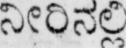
ನೀರಿನಲ್ಲಿ
